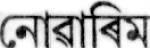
নোৱাৰিম
